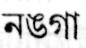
নঙগা
